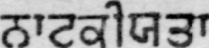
ਨਾਟਕੀਯਤਾ
